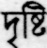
দৃষ্টি
